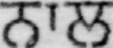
ਨਾਲ
